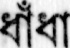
ধাঁধা
